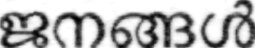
ജനങ്ങള്‍
